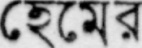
হেমের
